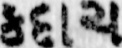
કદાચ
